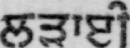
ਲੜਾਈ
